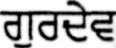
ਗੁਰਦੇਵ
